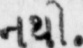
નથી.
